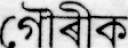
গৌৰীক
